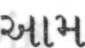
આમ
